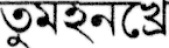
তুমহনখ্রে
